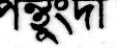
পন্থুংদা
